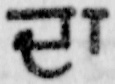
ਦਾ
